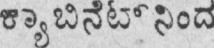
ಕ್ಯಾಬಿನೆಟ್‌ನಿಂದ
